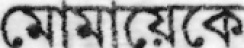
মোমায়েকে
